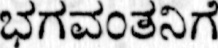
ಭಗವಂತನಿಗೆ
